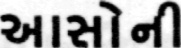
આસોની
